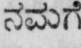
ನಮಗೆ
